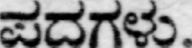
ಪದಗಳು.
